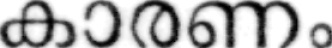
കാരണം
